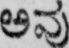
ಅವು
